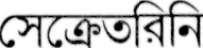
সেক্রেতরিনি
